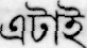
এটাই
